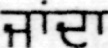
ਜਾਂਦਾ
